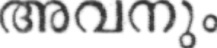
അവനും
